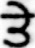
ਤੇ
